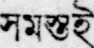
সমস্তই
